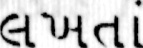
લખતાં
